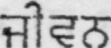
ਜੀਵਨ
